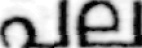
പല
